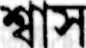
শ্বাস
